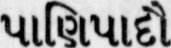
પાણિપાદૌ
